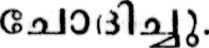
ചോദിച്ചു.
